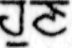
ਹੁਣ
